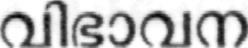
വിഭാവന
